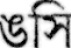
ঙসি
